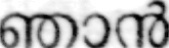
ഞാന്‍
